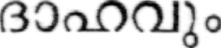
ദാഹവും
